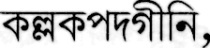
কল্লকপদগীনি,
